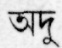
অদু
